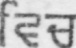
ਵਿਚ
